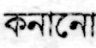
কনানো
